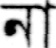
না
